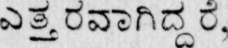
ಎತ್ತರವಾಗಿದ್ದರೆ,
